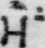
ਮੈਂ
